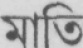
মাতি
